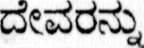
ದೇವರನ್ನು
